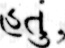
હતું,
